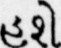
હશે
